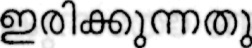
ഇരിക്കുന്നതു
